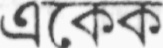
একেক
